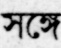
সঙ্গে
